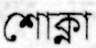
শোক্না
